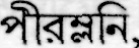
পীরম্লনি,
